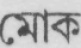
মোক
